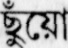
ছুঁয়ো
